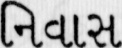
નિવાસ
